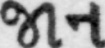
જાન
